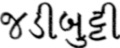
જડીબુટ્ટી
